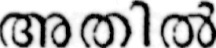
അതില്‍
